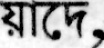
য়াদে,
